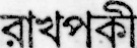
রাখপকী
